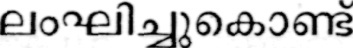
ലംഘിച്ചുകൊണ്ട്
